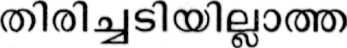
തിരിച്ചടിയില്ലാത്ത
